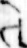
તે
